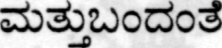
ಮತ್ತುಬಂದಂತೆ
